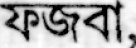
ফজবা,
